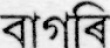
বাগৰি
